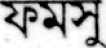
ফমসু
